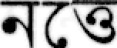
নত্তে
